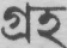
গ্ৰহ
